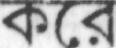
করে
